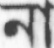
না
